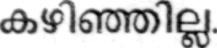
കഴിഞ്ഞില്ല.
